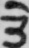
ਤੇ
